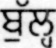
ਬੁੱਲ੍ਹ
